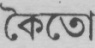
কৈতো
